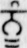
ਨੂੰ
